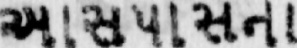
આસપાસના
